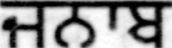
ਜਨਾਬ
